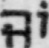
ਜਾਂ
